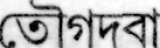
তৌগদবা
